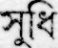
সুধি
